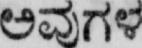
ಅವುಗಳ
